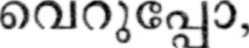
വെറുപ്പോ,
